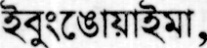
ইবুংঙোয়াইমা,
